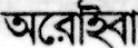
অরোইবা
